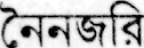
নৈনজরি
